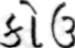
કોઉ
